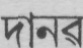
দানৱ
